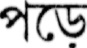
পড়ে
